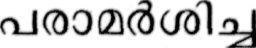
പരാമര്‍ശിച്ച
